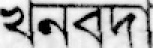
খনবদা
